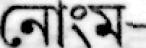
নোংম-
